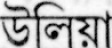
উলিয়া
